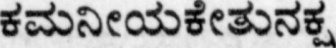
ಕಮನೀಯಕೇತುನಕ್ಷ
